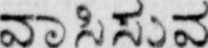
ವಾಸಿಸುವ
